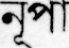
নূপা
